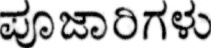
ಪೂಜಾರಿಗಳು
